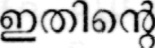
ഇതിന്റെ
